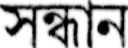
সন্ধান
